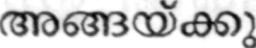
അങ്ങയ്ക്കു
